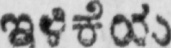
ಇಳಿಕೆಯ
